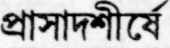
প্রাসাদশীর্ষে
